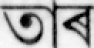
তাৰ
